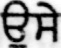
ਉਸੇ
